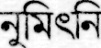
নুমিৎনি
